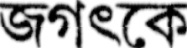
জগৎকে
